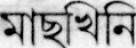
মাছখিনি
